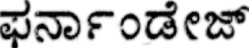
ಫರ್ನಾಂಡೇಜ್
